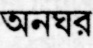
অনঘর
